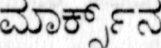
ಮಾರ್ಕ್ಸ್‌ನ
